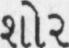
શોર
